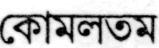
কোমলতম
